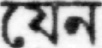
যেন
